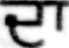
ਦਾ
